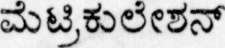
ಮೆಟ್ರುಕ್ಯುಲೇಶನ್
